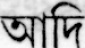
আদি
